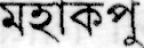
মহাকপু
